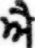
ਐ
